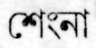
শেংনা
